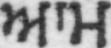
ਆਮ
